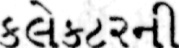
કલેક્ટરની
